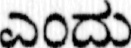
ಎಂದು
